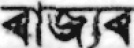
ৰাজ্যৰ
